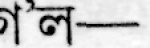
গ'ল-
